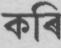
কৰি
